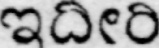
ಇದೀರಿ
